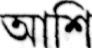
আশি
